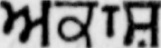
ਅਕਾਸ਼
